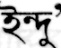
ইন্দু’
